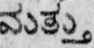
ಮತ್ತು
